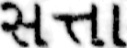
સત્તા
